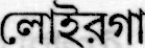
লোইরগা
